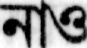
নাও
